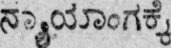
ನ್ಯಾಯಾಂಗಕ್ಕೆ
